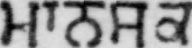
ਮਾਨਸਕ
